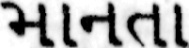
માનતા
